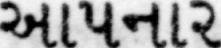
આપનાર
